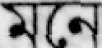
মনে
